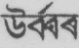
উৰ্ব্বৰ
